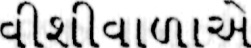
વીશીવાળાએ
